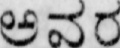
ಅವರ
